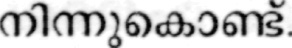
നിന്നുകൊണ്ട്.
